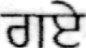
ਗਏ
